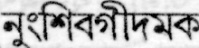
নুংশিবগীদমক
